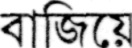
বাজিয়ে
